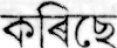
কৰিছে
